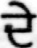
ਦੇ
